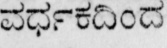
ವರ್ಧಕದಿಂದ
